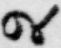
જ
